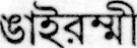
ঙাইরম্মী
